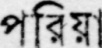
পরিয়া
